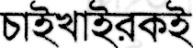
চাইখাইরকই
